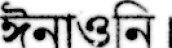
ঈনাওনি।
